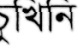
চুখিনি
